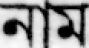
নাম
